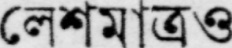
লেশমাত্রও
